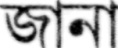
জানা
